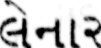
લેનાર
